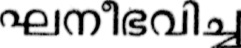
ഘനീഭവിച്ച
